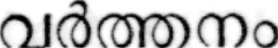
വര്‍ത്തനം
